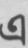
এ
